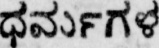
ಧರ್ಮಗಳ
